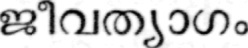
ജീവത്യാഗം
